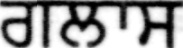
ਗਲਾਸ
